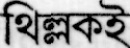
থিল্লকই
